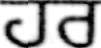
ਹਰ
